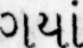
ગયાં
